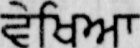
ਵੇਖਿਆ
